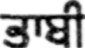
ਭਾਬੀ
